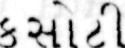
કસોટી
